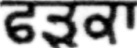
ਫੜਕਾ
